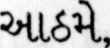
આઠમે,
